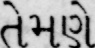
તેમણે
